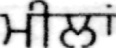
ਮੀਲਾਂ
